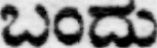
ಬಂದು
